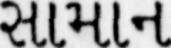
સામાન
